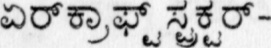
ಏರ್‌ಕ್ರಾಫ್ಟ್ ಸ್ಟ್ರಕ್ಟರ್-
